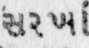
સરખાં
